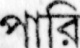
পারি
